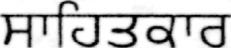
ਸਾਹਿਤਕਾਰ
